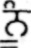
ਨੂੰ
